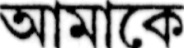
আমাকে
